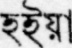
হইয়া
